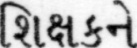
શિક્ષકને
